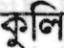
কুলি
